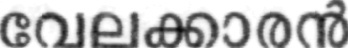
വേലക്കാരന്‍
